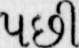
પછી
